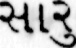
સારુ
